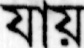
যায়
